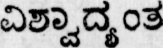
ವಿಶ್ವಾದ್ಯಂತ
